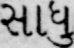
સાધુ
